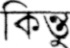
কিন্তু
